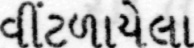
વીંટળાયેલા
